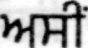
ਅਸੀਂ
